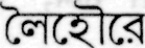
লৈহৌরে
